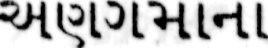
અણગમાના
